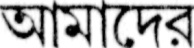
আমাদের
